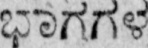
ಭಾಗಗಳ
